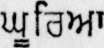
ਘੂਰਿਆ
